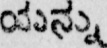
ಯನ್ನು
